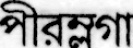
পীরম্লগা
